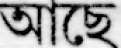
আছে
